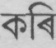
কৰি
